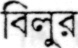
বিলুর
